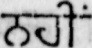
ਨਹੀਂ
